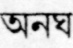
অনঘ
